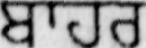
ਬਾਹਰ
